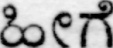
ಹೀಗೆ
